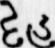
દેહ
